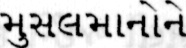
મુસલમાનોને
